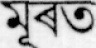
মূৰত
